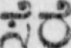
ಸೆರೆ
